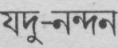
যদু-নন্দন
